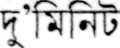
দু’মিনিট
